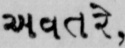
અવતરે,
